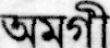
অমগী
